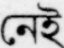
নেই
